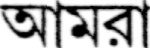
আমরা
